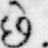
છે.
